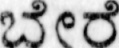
ಬೇರೆ
